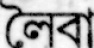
লৈবা
